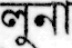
লুনা
